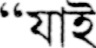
“যাই
